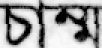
চাম্ম
